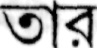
তার
